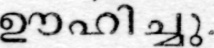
ഊഹിച്ചു.
